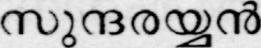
സുന്ദരയ്യന്‍
